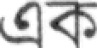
এক
